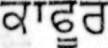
ਕਾਫੂਰ
